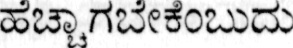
ಹೆಚ್ಚಾಗಬೇಕೆಂಬುದು
